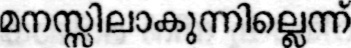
മനസ്സിലാകുന്നില്ലെന്ന്
